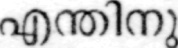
എന്തിനു
